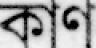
কাণ
